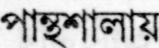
পান্থশালায়
